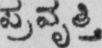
ಪ್ರವೃತ್ತಿ
